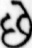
છે
